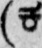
(ಕ
